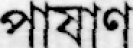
পাষাণ
